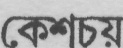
কেশচয়
